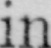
in
